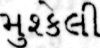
મુશ્કેલી
